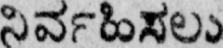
ನಿರ್ವಹಿಸಲು
